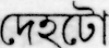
দেহটো
